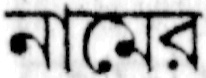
নামের
